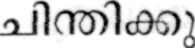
ചിന്തിക്കു
